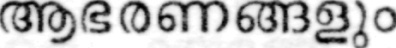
ആഭരണങ്ങളും
